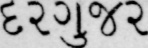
દરગુજર
